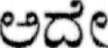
ಅದೇ
